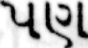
પણ
